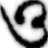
ও
